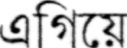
এগিয়ে
